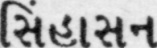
સિંહાસન
